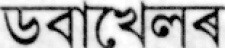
ডবাখেলৰ
